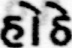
હોઠે
